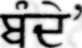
ਬੰਦੇ'
